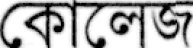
কোলেজ
